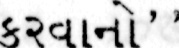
કરવાનો"
